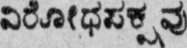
ವಿರೋಧಪಕ್ಷವು
